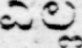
ಎಲ್ಲ
